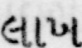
લાખ
